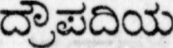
ದ್ರೌಪದಿಯ
